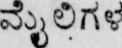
ಮೈಲಿಗಳ
